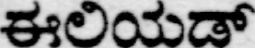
ಈಲಿಯಡ್
